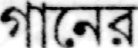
গানের
